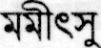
মমীৎসু
